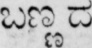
ಬಣ್ಣದ
